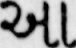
આ
